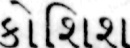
કોશિશ
